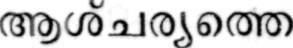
ആശ്ചര്യത്തെ
